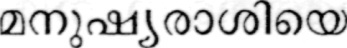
മനുഷ്യരാശിയെ
